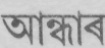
আন্ধাৰ
